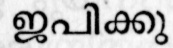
ജപിക്കു
